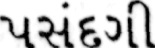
પસંદગી
